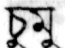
চুমু
